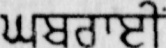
ਘਬਰਾਈਂ
